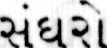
સંઘરો
